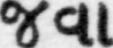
જવા
